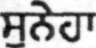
ਸੁਨੇਹਾ
